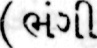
(ભંગી
